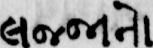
લજ્જાનો
